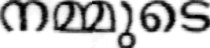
നമ്മുടെ
